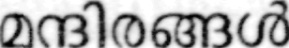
മന്ദിരങ്ങള്‍
